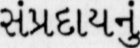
સંપ્રદાયનું
